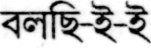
বলছি-ই-ই
